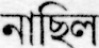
নাছিল
